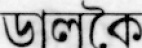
ডালকৈ
